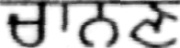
ਚਾਨਣ
